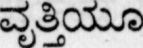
ವೃತ್ತಿಯೂ
